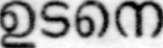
ഉടനെ
